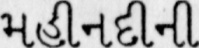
મહીનદીની
